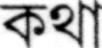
কথা
